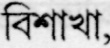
বিশাখা,
